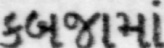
કબજામાં
